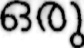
ഒരു
